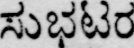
ಸುಭಟರ
